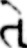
તે
